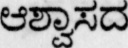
ಆಶ್ವಾಸದ
